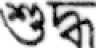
শুদ্ধ
